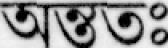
অন্ততঃ
